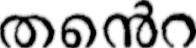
തന്റെ
